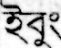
ইবুং
